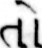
તો
